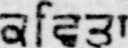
ਕਵਿਤਾ
